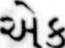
એક
